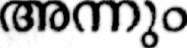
അന്നും
